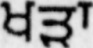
ਖੜਾ
